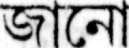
জানো
